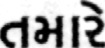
તમારે
